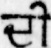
ਦੀ
